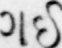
ગઈ
